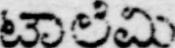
ಟಾಲೆಮಿ
